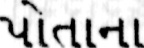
પોતાના
